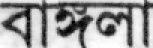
বাঙ্গলা
